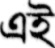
এই
